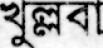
খুল্লবা
